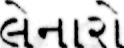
લેનારો
